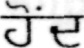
ਹੋਂਦ
